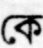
কে
